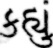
કહ્યું
